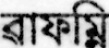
ৱাফম্নি
